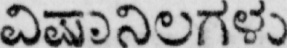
ವಿಷಾನಿಲಗಳು
